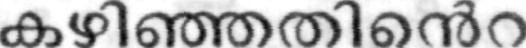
കഴിഞ്ഞതിന്റെ
